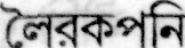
লৈরকপনি
